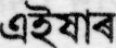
এইষাৰ
